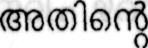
അതിന്റെ
